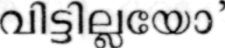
വിട്ടില്ലയോ'
